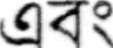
এবং
